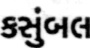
કસુંબલ
